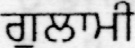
ਗੁਲਾਮੀ
